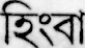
হিংবা
